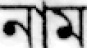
নাম
